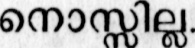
നൊസ്സില്ല.
